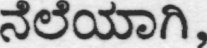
ನೆಲೆಯಾಗಿ,
